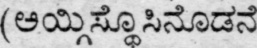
(ಅಯ್ಗಿಸ್ಥೊಸಿನೊಡನೆ
